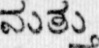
ಮತ್ತು
